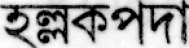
হল্লকপদা
